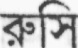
রুসি
